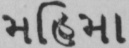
મહિમા
